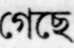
গেছে
